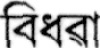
বিধৱা
